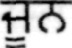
ਜੂਨ
